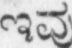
ಇವು
